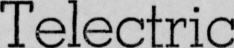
Telectric
